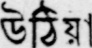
উঠিয়া
